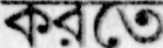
করতে
